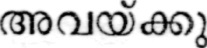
അവയ്ക്കു
